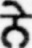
ਨੇ
